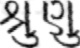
શ્રુણુ
